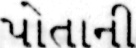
પોતાની
